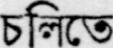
চলিতে
